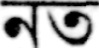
নত
